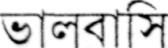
ভালবাসি
